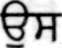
ਉਸ
